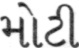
મોટી
